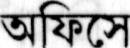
অফিসে
